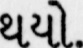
થયો.
